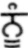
ਨੂੰ
